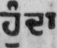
ਹੁੰਦਾ
